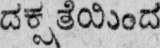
ದಕ್ಷತೆಯಿಂದ
